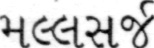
મલ્લસર્જ
